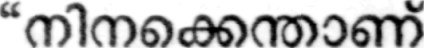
“നിനക്കെന്താണ്
